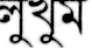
লুখুম
